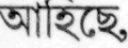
আহিছে,
